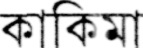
কাকিমা
